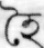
হৈ
